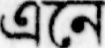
এনে
